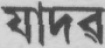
যাদৱ
